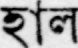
হাল
